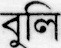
বুলি
